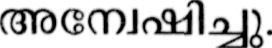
അന്വേഷിച്ചു.
